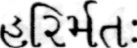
હરિર્મતઃ
